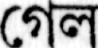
গেল
